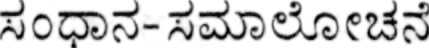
ಸಂಧಾನ-ಸಮಾಲೋಚನೆ
